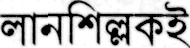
লানশিল্লকই
